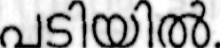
പടിയില്‍.
